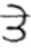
ਤੇ
